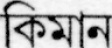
কিমান
